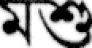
মশু
